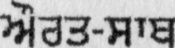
ਔਰਤ-ਸਾਥ
